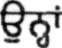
ਉਨ੍ਹਾਂ
